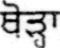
ਥੋੜ੍ਹਾ
